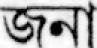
জনা
